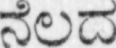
ನೆಲದ
